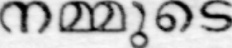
നമ്മുടെ
